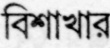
বিশাখার
